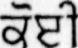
ਕੋਈ
